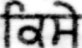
ਕਿਸੇ
